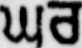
ਘਰ
